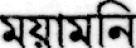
ময়ামনি
